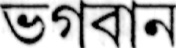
ভগবান
